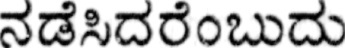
ನಡೆಸಿದರೆಂಬುದು
